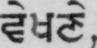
ਵੇਖਣੇ,
